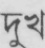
দুখ
